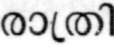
രാത്രി
